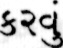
કરવું
